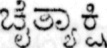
ಚೈತ್ಯಾಕ್ಷಿ
